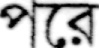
পরে
